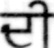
ਦੀ
